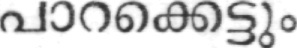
പാറക്കെട്ടും
